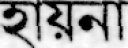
হায়না
